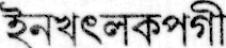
ইনখৎলকপগী
